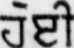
ਹੋਈ
